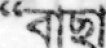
"বাছা
